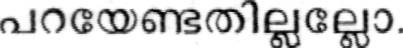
പറയേണ്ടതില്ലല്ലോ.
